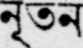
নূতন
